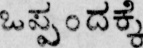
ಒಪ್ಪಂದಕ್ಕೆ
